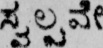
ಸ್ವಲ್ಪವೇ
